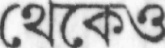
থেকেও
